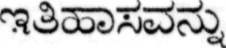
ಇತಿಹಾಸವನ್ನು
